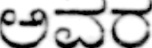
ಅವರ
